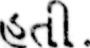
હતી.
